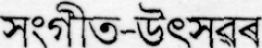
সংগীত-উৎসৱৰ
